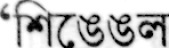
‘শিঙেঙল
